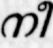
നീ
